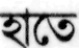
হাতে
